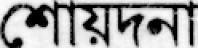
শোয়দনা
